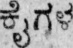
ಕೈಗಳ
